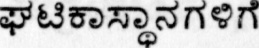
ಘಟಿಕಾಸ್ಥಾನಗಳಿಗೆ
